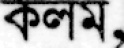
কলম,
